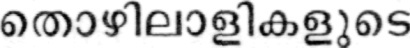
തൊഴിലാളികളുടെ
